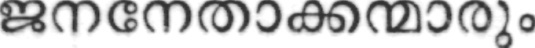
ജനനേതാക്കന്മാരും
